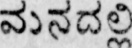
ಮನದಲ್ಲಿ
